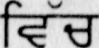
ਵਿੱਚ
